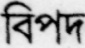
বিপদ
